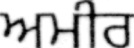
ਅਮੀਰ
